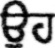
ਉਹ
